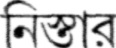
নিস্তার
